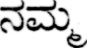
ನಮ್ಮ
